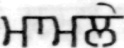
ਮਾਮਲੇ
